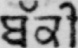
ਬੱਕੀ
